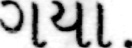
ગયા.
